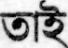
তাই
